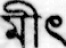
মীৎ
